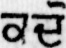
ਕਦੋ
